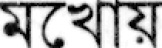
মখোয়
